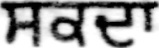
ਸਕਦਾ
